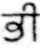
ਭੀ
